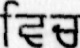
ਵਿਚ
